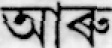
আৰু
